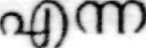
എന്ന
